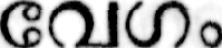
വേഗം
